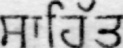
ਸਾਹਿੱਤ
